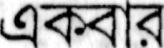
একবার
